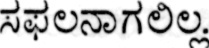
ಸಫಲನಾಗಲಿಲ್ಲ.
